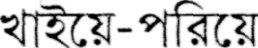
খাইয়ে-পরিয়ে
